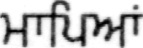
ਮਾਪਿਆਂ
